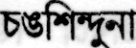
চঙশিন্দুনা
